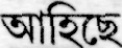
আহিছে
